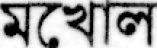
মখোল
